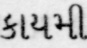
કાયમી
